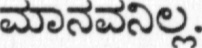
ಮಾನವನಿಲ್ಲ.
